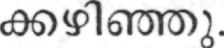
ക്കഴിഞ്ഞു.
